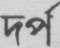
দৰ্প
